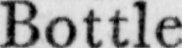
Bottle
